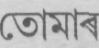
তোমাৰ
